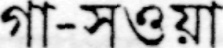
গা-সওয়া
